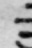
ਤੇ
